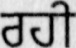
ਰਹੀ
